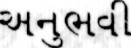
અનુભવી
